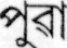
পুৱা
